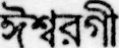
ঈশ্বরগী
